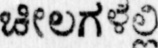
ಚೀಲಗಳಲ್ಲಿ
